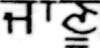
ਜਾਣੂ
